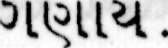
ગણાય.
